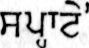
ਸਪ੍ਹਾਟੇ'
